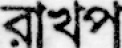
রাখপ
